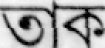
তাক
